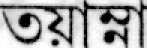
তয়াম্না
